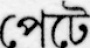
পেটে
